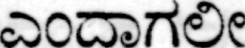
ಎಂದಾಗಲೀ
